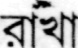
রাখা
